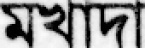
মখাদা
